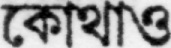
কোথাও
